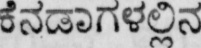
ಕೆನಡಾಗಳಲ್ಲಿನ
